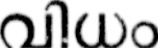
വിധം
